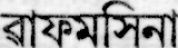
ৱাফমসিনা
